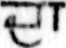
ਦਾ
